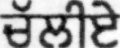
ਚੱਲੀਏ
